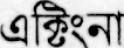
এক্টিংনা
